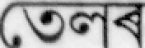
তেলৰ
